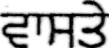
ਵਾਸਤੇ
